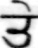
ਤੇ
